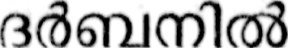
ദര്‍ബനില്‍
